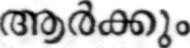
ആര്‍ക്കും
